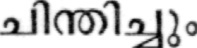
ചിന്തിച്ചും
